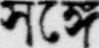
সঙ্গে
